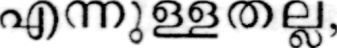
എന്നുള്ളതല്ല,
